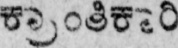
ಕ್ರಾಂತಿಕಾರಿ
